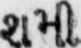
શમી
